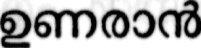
ഉണരാന്‍
